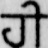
ਹੀ
